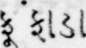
ફુંફાડા
